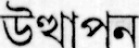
উত্থাপন
